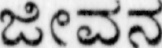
ಜೀವನ
